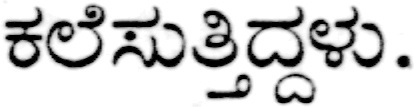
ಕಲೆಸುತ್ತಿದ್ದಳು.
